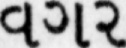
વગર
